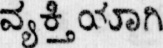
ವ್ಯಕ್ತಿಯಾಗಿ
